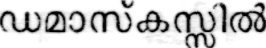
ഡമാസ്കസ്സില്‍
